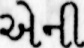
એની
